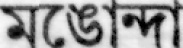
মঙোন্দা
